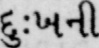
દુઃખની
